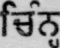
ਚਿੰਨ੍ਹ
